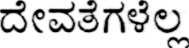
ದೇವತೆಗಳೆಲ್ಲ
